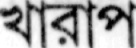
খারাপ
